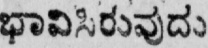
ಭಾವಿಸಿರುವುದು
